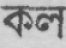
কল
